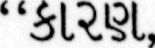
"કારણ,
